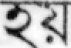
হয়
